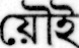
য়ৌই
